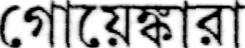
গোয়েঙ্কারা
